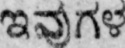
ಇವುಗಳ
